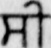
ਸੀ
